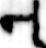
ન
